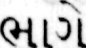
ભાગે
